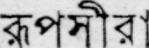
রূপসীরা
